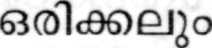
ഒരിക്കലും
